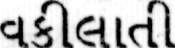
વકીલાતી
